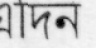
এদিন
